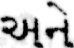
અને
